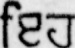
ਇਹ
